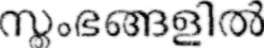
സ്തംഭങ്ങളില്‍
